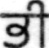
ਭੀ
